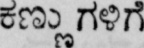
ಕಣ್ಣುಗಳಿಗೆ
